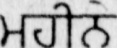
ਮਹੀਨੇ
